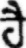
ਹੈ
